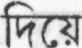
দিয়ে
